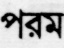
পরম
